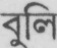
বুলি
